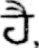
ਹੈ,
